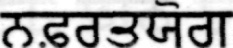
ਨਫ਼ਰਤਯੋਗ
